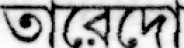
তারেদো
